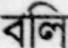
বলি
